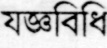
যজ্ঞবিধি
